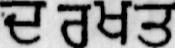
ਦਰਖਤ
